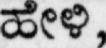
ಹೇಳಿ,
